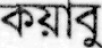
কয়াবু
